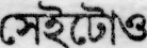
সেইটোও
